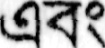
এবং
